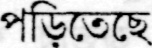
পড়িতেছে
